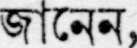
জানেন,
